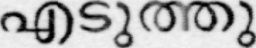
എടുത്തു
